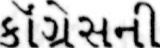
કૉંગ્રેસની
